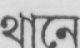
থানে
